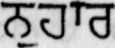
ਨੁਹਾਰ
